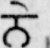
ਨੇ
